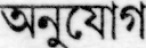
অনুযোগ
